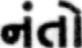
નંતો
